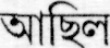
আছিল
